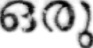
ഒരു
